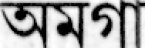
অমগা
